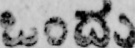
ಒಂದು
